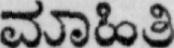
ಮಾಹಿತಿ
